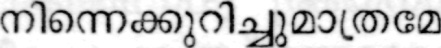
നിന്നെക്കുറിച്ചുമാത്രമേ
